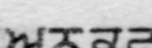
ਅਨੁਭਵ
